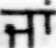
ਜਾਂ
